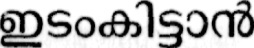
ഇടംകിട്ടാന്‍
